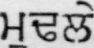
ਮੁਢਲੇ
